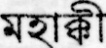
মহাক্কী
